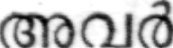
അവര്‍
